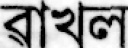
ৱাখল
